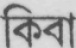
কিবা
